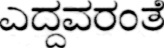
ಎದ್ದವರಂತೆ
